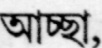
আচ্ছা,
